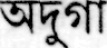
অদুগা
